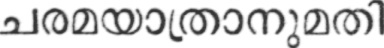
ചരമയാത്രാനുമതി
